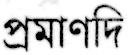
প্রমাণদি
